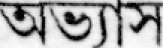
অভ্যাস
